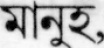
মানুহ,
